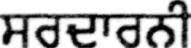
ਸਰਦਾਰਨੀ
